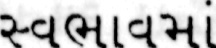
સ્વભાવમાં
